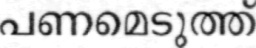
പണമെടുത്ത്
